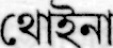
থোইনা
